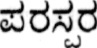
ಪರಸ್ಪರ
